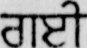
ਗਈ
